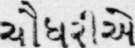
ચૌધરીએ
